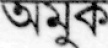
অমুক
